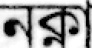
নক্না
